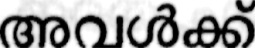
അവള്‍ക്ക്
